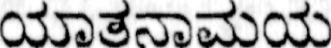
ಯಾತನಾಮಯ
